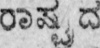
ರಾಷ್ಟ್ರದ
